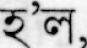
হ'ল,
